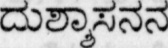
ದುಶ್ಯಾಸನನ
